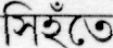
সিহঁতে
